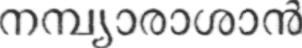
നമ്പ്യാരാശാന്‍
